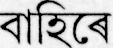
বাহিৰে
